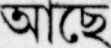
আছে
